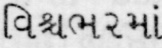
વિશ્ચવભરમાં
